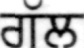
ਗੱਲ
